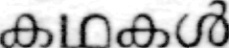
കഥകള്‍
